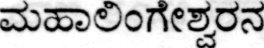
ಮಹಾಲಿಂಗೇಶ್ವರನ
